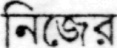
নিজের
